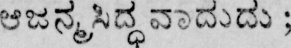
ಆಜನ್ಮಸಿದ್ಧವಾದುದು;
